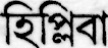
হিপ্লিবা
